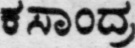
ಕಸಾಂದ್ರ
